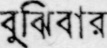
বুঝিবার
